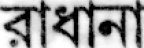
রাধানা
